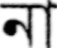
না
